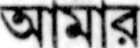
আমার
